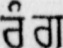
ਰੰਗ
